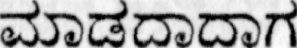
ಮಾಡದಾದಾಗ
